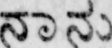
ನಾನು
